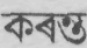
কৰন্ত
